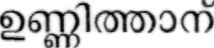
ഉണ്ണിത്താന്
